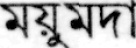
ময়ুমদা
